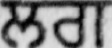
ਲਗ
